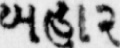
બહાર
